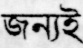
জন্যই
